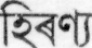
হিৰণ্য
